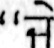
''ਜੇ
